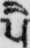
ਪੈ
